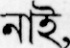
নাই,
